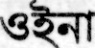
ওইনা
